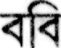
ববি
